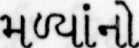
મળ્યાંનો
